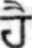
ਹੈ
